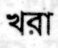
খরা
